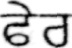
ਫੇਰ
